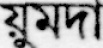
য়ুমদা
